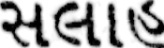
સલાહ
